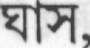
ঘাস,
